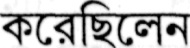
করেছিলেন
